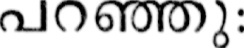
പറഞ്ഞു:
